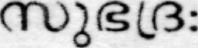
സുഭദ്ര:
